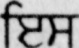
ਇਸ
